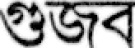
গুজব
